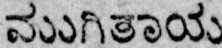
ಮುಗಿತಾಯ
